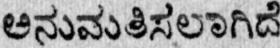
ಅನುಮತಿಸಲಾಗಿದೆ
